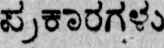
ಪ್ರಕಾರಗಳು
